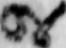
જ
